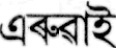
এৰুৱাই
